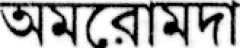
অমরোমদা
